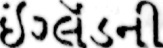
ઇંગ્લૅંડની
